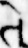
તે
